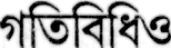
গতিবিধিও
